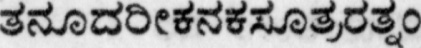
ತ್ತ
